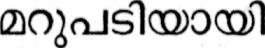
മറുപടിയായി
